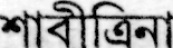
শাবীত্রিনা
